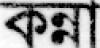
কন্না
